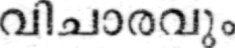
വിചാരവും
